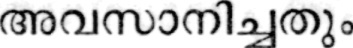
അവസാനിച്ചതും
